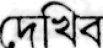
দেখিব
